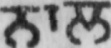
ਨਾਲ
